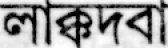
লাক্কদবা
